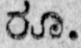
ರೂ.
